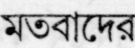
মতবাদের
